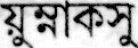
য়ুম্নাকসু
